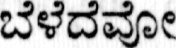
ಬೆಳೆದೆವೋ
